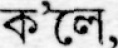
ক'লে,
